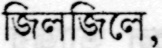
জিলজিলে,
